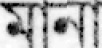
মানা
